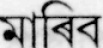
মাৰিব
